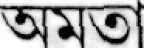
অমতা
